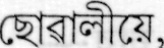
ছোৱালীয়ে,
